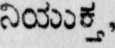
ನಿಯುಕ್ತ,
